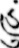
હું
